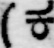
(ಕ
